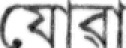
যোৱা
